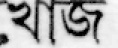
খোজ
